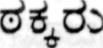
ಠಕ್ಕರು
